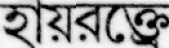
হায়রক্ত্রে
